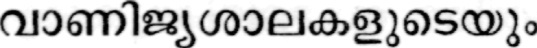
വാണിജ്യശാലകളുടെയും
